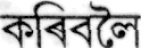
কৰিবলৈ
